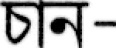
চান-
